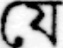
যে
